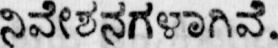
ನಿವೇಶನಗಳಾಗಿವೆ.
